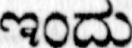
ಇಂದು
